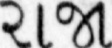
રાજા
